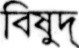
বিষুদ্
